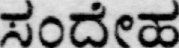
ಸಂದೇಹ
